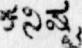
ಕನಿಷ್ಟ
